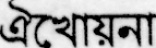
ঐখোয়না
